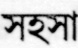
সহসা
